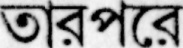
তারপরে
